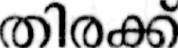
തിരക്ക്
